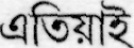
এতিয়াই
